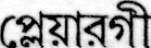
প্লেয়ারগী
